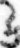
કે
